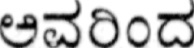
ಅವರಿಂದ
